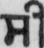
ਸੀ
